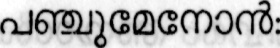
പഞ്ചുമേനോന്‍:
